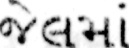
જેલમાં
